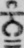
ਨੂੰ
